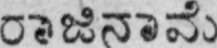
ರಾಜಿನಾಮೆ
